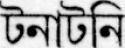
টনাটনি
